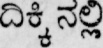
ದಿಕ್ಕಿನಲ್ಲಿ
